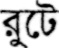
রুটে
